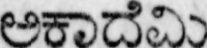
ಅಕಾದೆಮಿ
